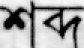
শব্দ
